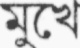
মুখে
